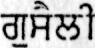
ਗੁਸੈਲੀ
